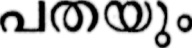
പതയും
